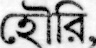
হৌরি,
